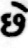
છે
